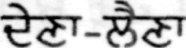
ਦੇਣਾ-ਲੈਣਾ
